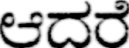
ಆದರೆ
